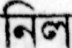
নিল
